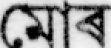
মোৰ
